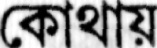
কোথায়
